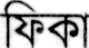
ফিকা
